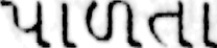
પાળતા
